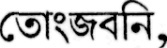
তোংজবনি,
